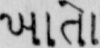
ખાતો
